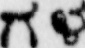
ಗಳ
